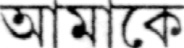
আমাকে
